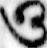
ও
